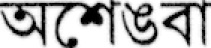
অশেঙবা
